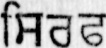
ਸਿਰਫ
